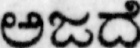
ಅಜದೆ
